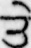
ਤੇ
